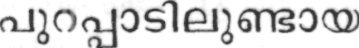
പുറപ്പാടിലുണ്ടായ
